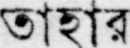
তাহার
